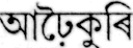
আঢ়ৈকুৰি
